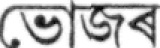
ভোজৰ
